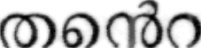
തന്റെ
